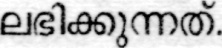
ലഭിക്കുന്നത്.
